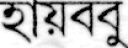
হায়ববু
